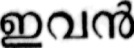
ഇവന്‍
